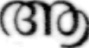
ആ
